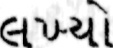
લખ્યો
